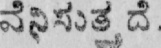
ವೆನಿಸುತ್ತದೆ.
